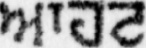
ਆਹਟ
